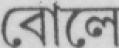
বোলে
